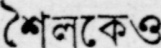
শৈলকেও
